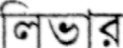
লিভার
